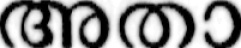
അതാ
